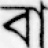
বা
